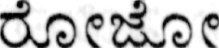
ರೋಜೋ
